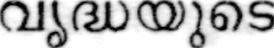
വൃദ്ധയുടെ
